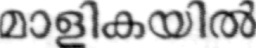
മാളികയില്‍
